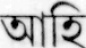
আহি
